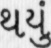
થયું
